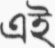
এই
